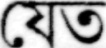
যেত
